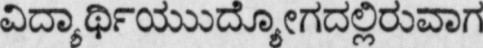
ವಿದ್ಯಾರ್ಥಿಯುದ್ಯೋಗದಲ್ಲಿರುವಾಗ
